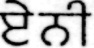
ਏਨੀ
